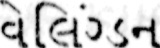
વેલિંગ્ડન
